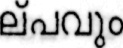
ല്പവും
